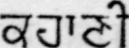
ਕਹਾਣੀ
